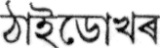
ঠাইডোখৰ
